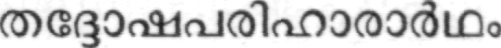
തദ്ദോഷപരിഹാരാര്‍ഥം
